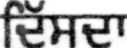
ਦਿੱਸਦਾ
